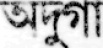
অদুগা
